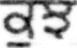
ਕੁਝ
